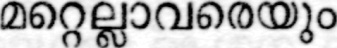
മറ്റെല്ലാവരെയും
